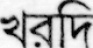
খরদি
